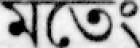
মতেং
